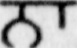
ਨਾ
